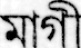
মাগী
